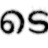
ടെ
